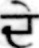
ਦੇ
